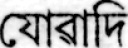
যোৱাদি
